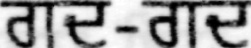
ਗਦ-ਗਦ
